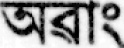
অৱাং
